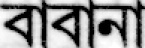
বাবানা
